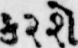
કરશે?
